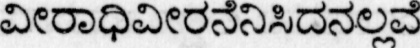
ವೀರಾಧಿವೀರನೆನಿಸಿದನಲ್ಲವೆ
